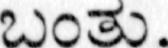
ಬಂತು.
